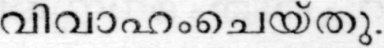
വിവാഹംചെയ്തു.
